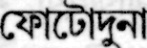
ফোটোদুনা
